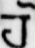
ਹੋ
